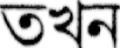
তখন
